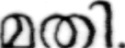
മതി.
